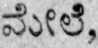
ಮೇಲೆ,
